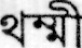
থম্মী
